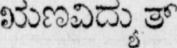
ಋಣವಿದ್ಯುತ್
